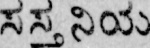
ಸಸ್ತನಿಯ
